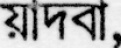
য়াদবা,
